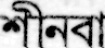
শীনবা
